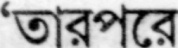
‘তারপরে
